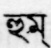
হুম্
